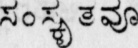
ಸಂಸ್ಕೃತವೂ
